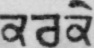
ਕਰਕੇ
